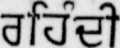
ਰਹਿੰਦੀ
